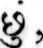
છું,
